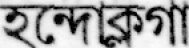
হন্দোক্লগা
